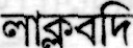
লাক্লবদি
